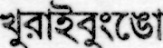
খুরাইবুংঙো
